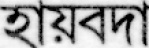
হায়বদা
